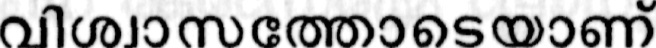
വിശ്വാസത്തോടെയാണ്
